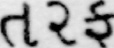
તરફ
